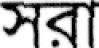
সরা
